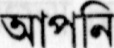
আপনি
